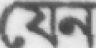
যেন
